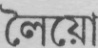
লৈয়ো
